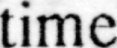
time
